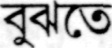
বুঝতে
